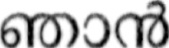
ഞാന്‍
